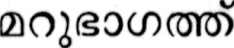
മറുഭാഗത്ത്
